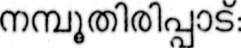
നമ്പൂതിരിപ്പാട്:
